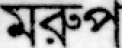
মরুপ
